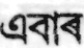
এবাৰ
